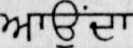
ਆਉਂਦਾ।
